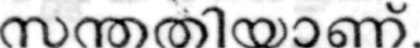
സന്തതിയാണ്.
